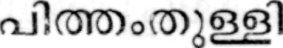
പിത്തംതുള്ളി
